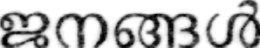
ജനങ്ങള്‍
